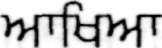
ਆਖਿਆ
